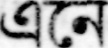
এনে
